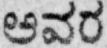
ಅವರ
